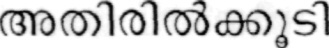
അതിരില്‍ക്കൂടി
